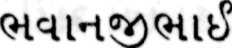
ભવાનજીભાઈ
